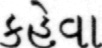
કહેવા
